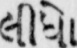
લીધો
